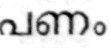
പണം
